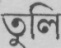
তুলি
